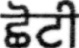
ਛੋਟੀ
